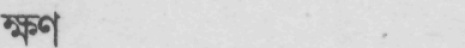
ক্ষণ
